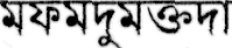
মফমদুমক্তদা
